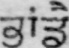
ਭਾਂਡੈ
